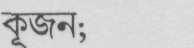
কূজন;
